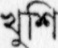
খুশি
